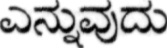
ಎನ್ನುವುದು
